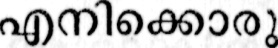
എനിക്കൊരു
